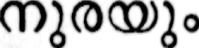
നുരയും
